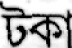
টকা
